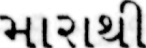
મારાથી
